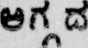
ಅಗ್ಗದ
